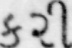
કરી
